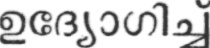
ഉദ്യോഗിച്ച്
